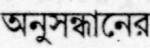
অনুসন্ধানের
